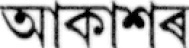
আকাশৰ
